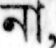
না,
